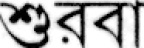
শুরবা
